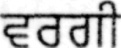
ਵਰਗੀ
